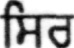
ਸਿਰ
